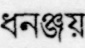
ধনঞ্জয়
